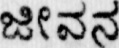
ಜೀವನ
